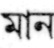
মান
